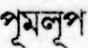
পূমলূপ
